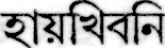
হায়খিবনি
